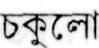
চকুলো
